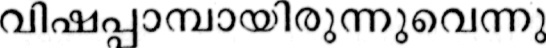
വിഷപ്പാമ്പായിരുന്നുവെന്നു
